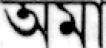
অমা
